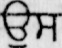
ਉਸ
